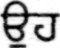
ਉਹ
